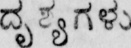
ದೃಶ್ಯಗಳು
